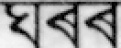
ঘৰৰ
